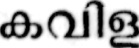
കവിള
